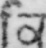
ਕਿ
